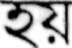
হয়
